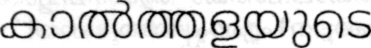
കാല്‍ത്തളയുടെ
